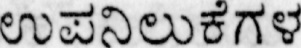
ಉಪನಿಲುಕೆಗಳ
